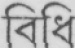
বিধি
